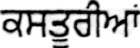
ਕਸਤੂਰੀਆਂ
